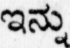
ಇನ್ನು
